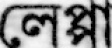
লেপ্পা
